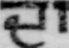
ਦਾ
